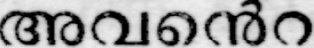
അവന്റെ
